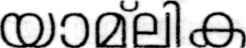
യാമ്ലിക
